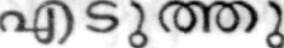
എടുത്തു
